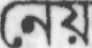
নেয়
